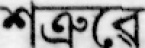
শত্রুৱে
